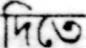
দিতে
